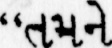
"તમને
